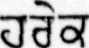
ਹਰੇਕ
